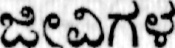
ಜೀವಿಗಳ
